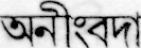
অনীংবদা
